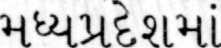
મધ્યપ્રદેશમાં
